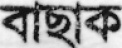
বাছাক
